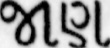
જાણ
